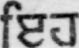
ਇਹ
